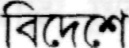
বিদেশে
